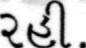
રહી.
